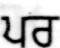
ਪਰ
